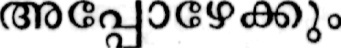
അപ്പോഴേക്കും
